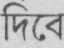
দিবে
